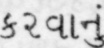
કરવાનું
